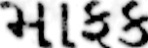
માફક
